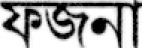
ফজনা
